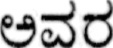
ಅವರ
